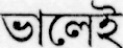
ভালেই
